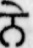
ਨੇ
